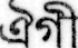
ঐগী
